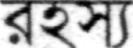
রহস্য
